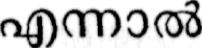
എന്നാല്‍
